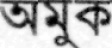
অমুক
